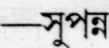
–সুপন্ন
